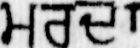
ਮਰਦਾ
